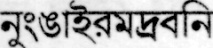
নুংঙাইরমদ্রবনি
